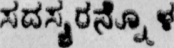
ಸದಸ್ಯರನ್ನೊಳ
